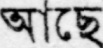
আছে
